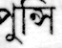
পুন্সি
